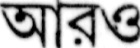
আরও
